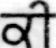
ਕੀ
